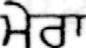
ਮੇਰਾ
